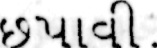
છપાવી.
